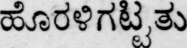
ಹೊರಳಿಗಟ್ಟಿತು
